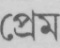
প্ৰেম
